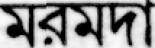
মরমদা
